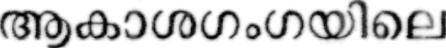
ആകാശഗംഗയിലെ
